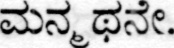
ಮನ್ಮಥನೇ.
